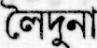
লৈদুনা
